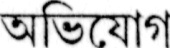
অভিযোগ
